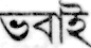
ভবাই
